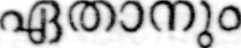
ഏതാനും
